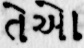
તેઓ
